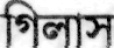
গিলাস
